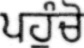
ਪਹੁੰਚੋ
